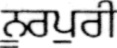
ਨੂਰਪੁਰੀ
